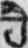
ਹੈ
